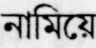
নামিয়ে
